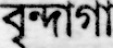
বৃন্দাগা
